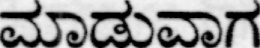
ಮಾಡುವಾಗ
